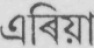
এৰিয়া
